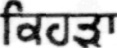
ਕਿਹੜਾ
